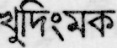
খুদিংমক
